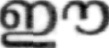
ഈ
